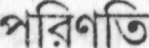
পরিণতি
